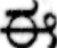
ಈ
